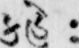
કહેઃ
